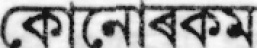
কোনোৰকম
